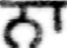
ਨਾ
